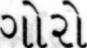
ગોરો
